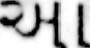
આ
